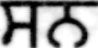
ਸਨ
